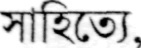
সাহিত্যে,
